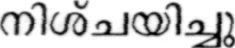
നിശ്ചയിച്ചു
